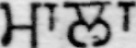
ਮਾਲਾ
